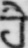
ਹੈ
